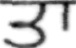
ਤਾਂ
